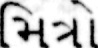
મિત્રો
